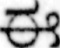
ಈ
